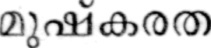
മുഷ്കരത
